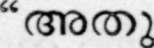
"അതു
